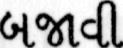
બજાવી
